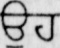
ਉਹ
